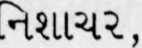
નિશાચાર,
